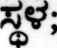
ಸ್ಥಳ;
